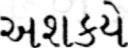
અશક્યે
